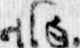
નહિ.
